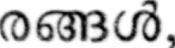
രങ്ങള്‍,
